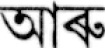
আৰু
